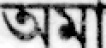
অমা
